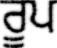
ਰੂਪ
